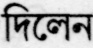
দিলেন
